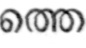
ത്തെ
